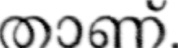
താണ്.
